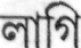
লাগি
